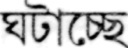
ঘটাচ্ছে
